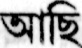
আছি
